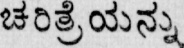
ಚರಿತ್ರೆಯನ್ನು
